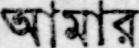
আমার
